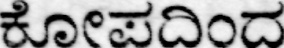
ಕೋಪದಿಂದ
